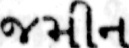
જમીન
